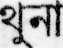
থুনা
